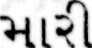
મારી
